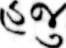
હજુ
